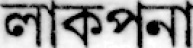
লাকপনা
